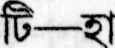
টি–হা
